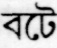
বটে
